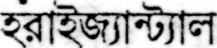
হরাইজ্যান্ট্যাল
